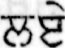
ਲਏ
